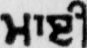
ਮਾਈ
